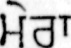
ਮੇਰਾ
